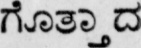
ಗೊತ್ತಾದ
